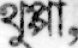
থুপ্পা,
